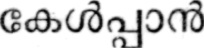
കേള്‍പ്പാന്‍
